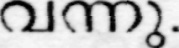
വന്നു.
